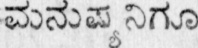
ಮನುಷ್ಯನಿಗೂ
